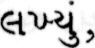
લખ્યું,
